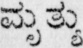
ಮೃತ್ಯು
